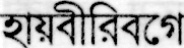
হায়বীরিবগে
